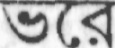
ভরে
